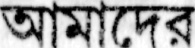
আমাদের
